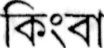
কিংবা
